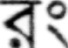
রং
